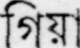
গিয়া
